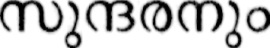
സുന്ദരനും
